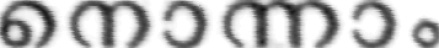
നൊന്നാം
